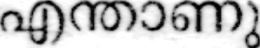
എന്താണു
